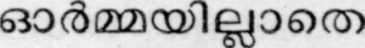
ഓര്‍മ്മയില്ലാതെ
